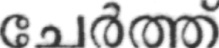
ചേര്‍ത്ത്
